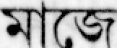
মাজে
